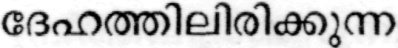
ദേഹത്തിലിരിക്കുന്ന
